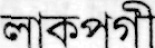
লাকপগী
